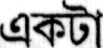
একটা
